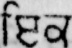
ਇਕ
